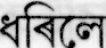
ধৰিলে
